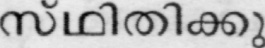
സ്ഥിതിക്കു
